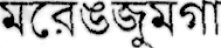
মরেঙজুমগা
